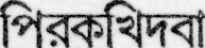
পিরকখিদবা
